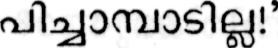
പിച്ചാമ്പാടില്ല!’
